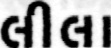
લીલા
